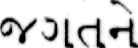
જગતને
